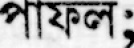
পাফল;
